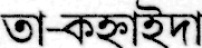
তা-কহ্নাইদা
